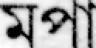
মপা
